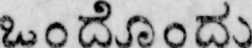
ಒಂದೊಂದು
